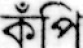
কঁপি
